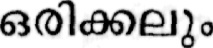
ഒരിക്കലും
